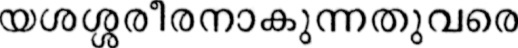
യശശ്ശരീരനാകുന്നതുവരെ
